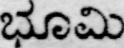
ಭೂಮಿ
